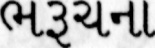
ભરૂચના
